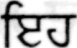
ਇਹ
